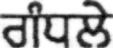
ਗੰਧਲੇ
